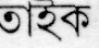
তাইক
